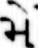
મેં
